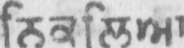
ਨਿਕਲਿਆ
